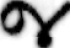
જ
